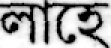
লাহে
